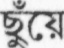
ছুঁয়ে
